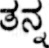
ತನ್ನ
